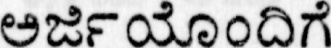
ಅರ್ಜಿಯೊಂದಿಗೆ
